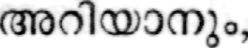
അറിയാനും,
